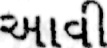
આવી
